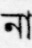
না
